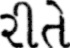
રીત
